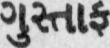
ગુસ્તાફ
